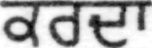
ਕਰਦਾ
